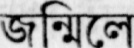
জন্মিলে
